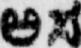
ಅಸ
